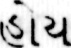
હોય
